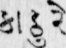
કાઠુરે
